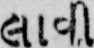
લાવી
